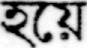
হয়ে
